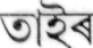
তাইৰ
